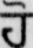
ਹੋ
